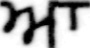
ਆ
